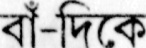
বাঁ-দিকে
